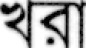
খরা
